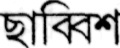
ছাব্বিশ
